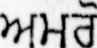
ਅਮਰੋ
